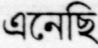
এনেছি
